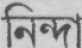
নিন্দা
